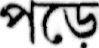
পড়ে
